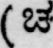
(ಚ
